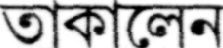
তাকালেন
